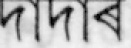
দাদাৰ
